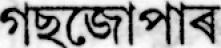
গছজোপাৰ
